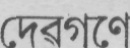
দেৱগণে
